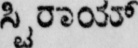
ಸ್ಟಿರಾಯ್
